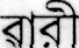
ৱারী
